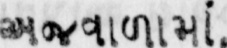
અજવાળામાં.
